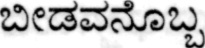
ಬೀಡವನೊಬ್ಬ
